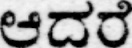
ಆದರೆ
